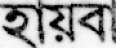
হায়বা
